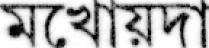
মখোয়দা
